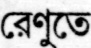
রেণুতে
